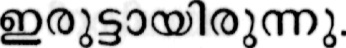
ഇരുട്ടായിരുന്നു.
